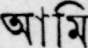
আমি
